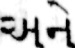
અને
